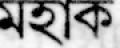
মহাক
